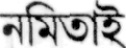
নমিতাই
